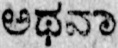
ಅಥವಾ
